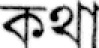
কথা
